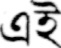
এই
